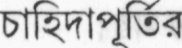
চাহিদাপূর্তির
